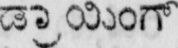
ಡ್ರಾಯಿಂಗ್
